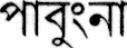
পাবুংনা
